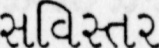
સવિસ્તર
